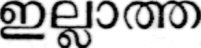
ഇല്ലാത്ത
